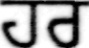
ਹਰ
